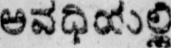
ಅವಧಿಯಲ್ಲಿ
